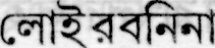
লোইরবনিনা
